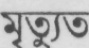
মৃত্যুত
